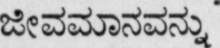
ಜೀವಮಾನವನ್ನು
